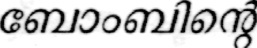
ബോംബിന്റെ
